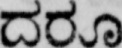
ದರೂ
